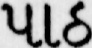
પાઠ
